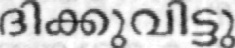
ദിക്കുവിട്ടു
